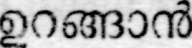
ഉറങ്ങാന്‍
